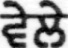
ਵੇਲੇ
